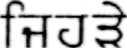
ਜਿਹੜੇ
